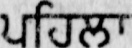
ਪਹਿਲਾ
